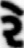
રે
